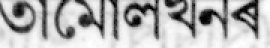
তামোলখনৰ
